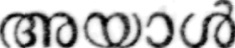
അയാള്‍
